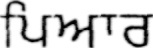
ਪਿਆਰ
